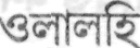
ওলালহি
